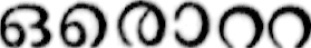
ഒരൊററ
